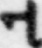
ન
